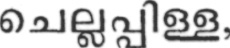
ചെല്ലപ്പിള്ള,
